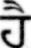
ਹੈ
